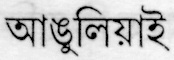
আঙুলিয়াই
